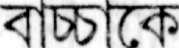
বাচ্চাকে
